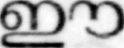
ഈ
